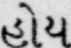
હોય
